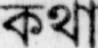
কথা
